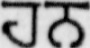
ਹਨ
